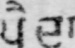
ਪੈਦਾ
